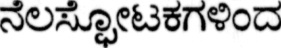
ನೆಲಸ್ಫೋಟಕಗಳಿಂದ
